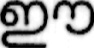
ഈ
